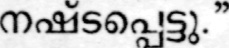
നഷ്ട്ടപ്പട്ടു.”
